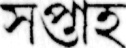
সপ্তাহ
